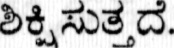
ಶಿಕ್ಷಿಸುತ್ತದೆ.
